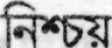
নিশ্চয়
